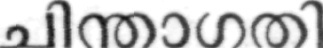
ചിന്താഗതി
